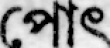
পোৎ
